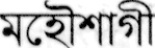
মহৌশাগী
